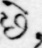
છે,
